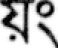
য়ং
